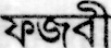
ফজবী
